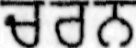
ਚਰਨ
